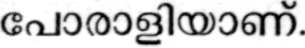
പോരാളിയാണ്.
